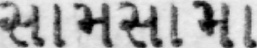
સામસામા
